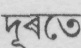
দূৰতে
